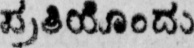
ಪ್ರತಿಯೊಂದು
